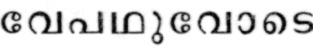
വേപഥുവോടെ
